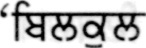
'ਬਿਲਕੁਲ
